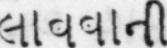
લાવવાની
